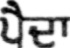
ਪੈਦਾ
